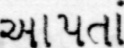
આપતાં
